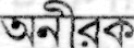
অনীরক
